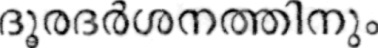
ദൂരദര്‍ശനത്തിനും
